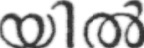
യില്‍
